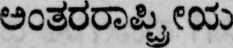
ಅಂತರರಾಷ್ಟ್ರೀಯ
